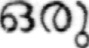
ഒരു
